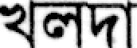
খলদা
